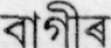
বাগীৰ
